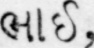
ભાઈ,
